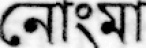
নোংমা
